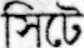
সিটে
